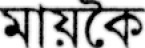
মায়কৈ
